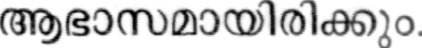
ആഭാസമായിരിക്കും.
